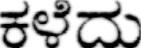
ಕಳೆದು
